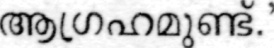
ആഗ്രഹമുണ്ട്.’
